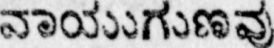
ವಾಯುಗುಣವು
